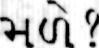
મળે?
